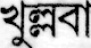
খুল্লবা
